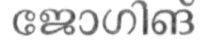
ജോഗിങ്
